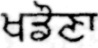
ਖਡੌਣਾ
